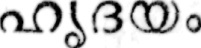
ഹൃദയം
